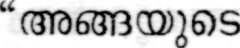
“അങ്ങയുടെ
